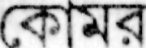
কোমর
